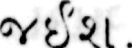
જઈશ.
